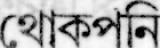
থোকপনি
